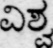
ವಿಶ್ವ
